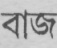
বাজ
